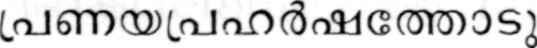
പ്രണയപ്രഹര്‍ഷത്തോടു
